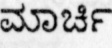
ಮಾರ್ಚಿ
